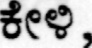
ಕೇಳಿ,
